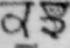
ਕੁਝ
